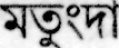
মতুংদা
